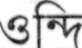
ওন্দি
